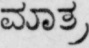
ಮಾತ್ರ
